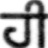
ਹੀ
